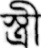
স্ত্রী
